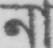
না
